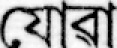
যোৱা
